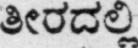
ತೀರದಲ್ಲಿ
